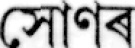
সোণৰ
